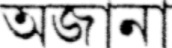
অজানা
